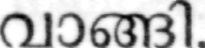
വാങ്ങി.
